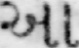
આ
